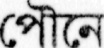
পৌনে
